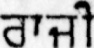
ਰਾਜੀ
